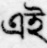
এই
